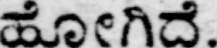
ಹೋಗಿದೆ.
